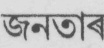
জনতাৰ
